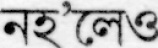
নহ'লেও
